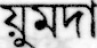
য়ুমদা
